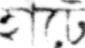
হাটে
